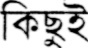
কিছুই
